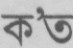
ক'ত
